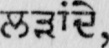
ਲੜਾਂਦੇ,
